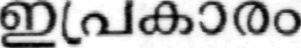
ഇപ്രകാരം
